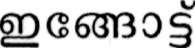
ഇങ്ങോട്ട്
